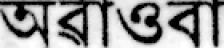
অৱাওবা
